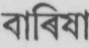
বাৰিষা
